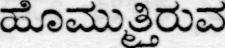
ಹೊಮ್ಮುತ್ತಿರುವ
